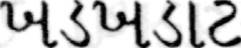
ખડખડાટ
